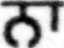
ਨਾ
